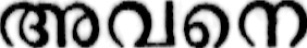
അവനെ
